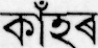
কাঁহৰ
